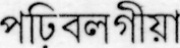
পঢ়িবলগীয়া
